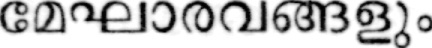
മേഘാരവങ്ങളും
